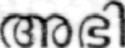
അഭി
